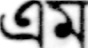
এম
